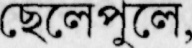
ছেলেপুলে,
